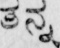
ತನ್ನ
